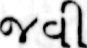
જવી
